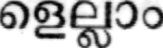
ളെല്ലാം
